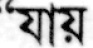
"যায়
